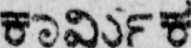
ಕಾರ್ಮಿಕ
